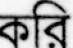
করি
